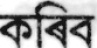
কৰিব
